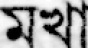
মখা
